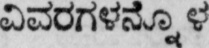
ವಿವರಗಳನ್ನೊಳ
